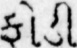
ફોડી
